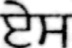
ਏਸ
